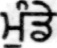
ਮੁੰਡੇ
